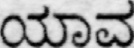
ಯಾವ
